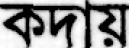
কদায়
